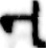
ન
